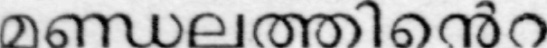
മണ്ഡലത്തിന്റെ
